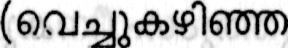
(വെച്ചുകഴിഞ്ഞ
